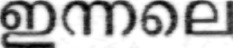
ഇന്നലെ
